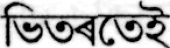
ভিতৰতেই
